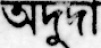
অদুদা
